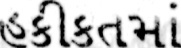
હકીકતમાં
